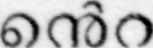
ന്റെ
